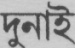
দুনাই
